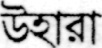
উহারা
